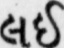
લઈ
